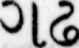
ગઢ
